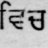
ਵਿਚ
